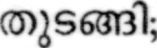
തുടങ്ങി;
